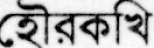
হৌরকখি
